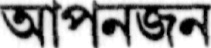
আপনজন
